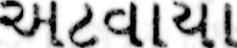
અટવાયા
